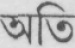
অতি
